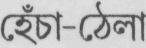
হেঁচা-ঠেলা
